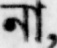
না,
